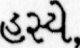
હસ્યે,
